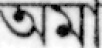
অমা
